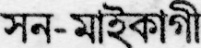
সন-মাইকাগী
